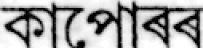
কাপোৰৰ
